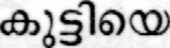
കുട്ടിയെ
